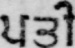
ਪਤੀ
